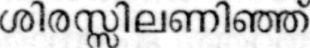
ശിരസ്സിലണിഞ്ഞ്
